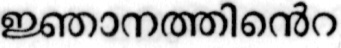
ജ്ഞാനത്തിന്റെ
